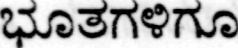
ಭೂತಗಳಿಗೂ
